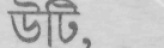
উটি,
